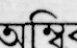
অম্বি
